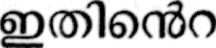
ഇതിന്റെ
